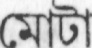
মোটা
